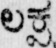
ಲಕ್ಷ
